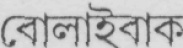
বোলাইবাক
